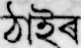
ঠাইৰ
